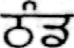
ਠੰਡ
